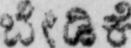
ಬೇಡಿಕೆ
